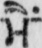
ਮੈਂ
